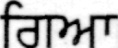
ਗਿਆ
